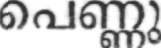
പെണ്ണു
